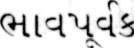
ભાવપૂર્વક
